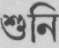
শুনি
